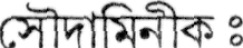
সৌদামিনীকঃ
